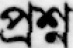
প্রশ্ন
